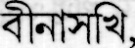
বীনাসখি,
